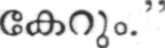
കേറും."
